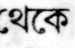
থেকে
